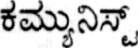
ಕಮ್ಯುನಿಸ್ಟ್
